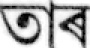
তাৰ
